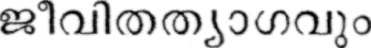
ജീവിതത്യാഗവും
